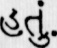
હતું.
